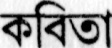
কবিতা
